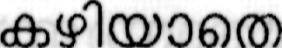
കഴിയാതെ
